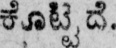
ಕೊಟ್ಟಿದೆ.
